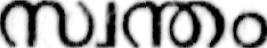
സ്വന്തം
